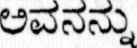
ಅವನನ್ನು
